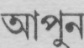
আপুন
